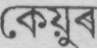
কেয়ুৰ
